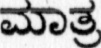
ಮಾತ್ರ
